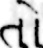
તો
